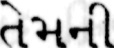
તેમની
